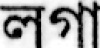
লগা
